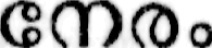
നേരം
